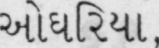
ઓઘરિયા,
